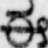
ಈ
